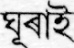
ঘূৰাই
